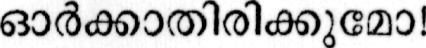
ഓര്‍ക്കാതിരിക്കുമോ!
